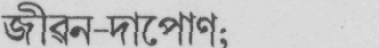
জীৱন-দাপোণ;
